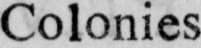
Colonies
